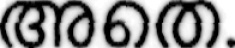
അതെ.
